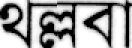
থল্লবা
